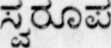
ಸ್ವರೂಪ
